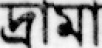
দ্রামা
